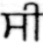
ਸੀ
